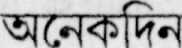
অনেকদিন
